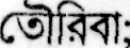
তৌরিবা;
